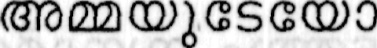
അമ്മയുടേയോ
